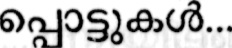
പ്പൊട്ടുകള്‍..
